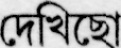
দেখিছো
